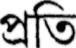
প্রতি
